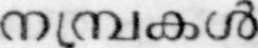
നമ്പ്രകള്‍
